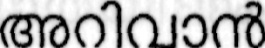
അറിവാന്‍
